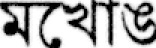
মখোঙ
